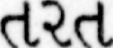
તરત
